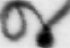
જ
